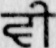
ਵੀ
